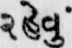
રહેવું
